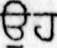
ਉਹ
